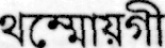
থম্মোয়গী
